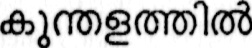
കുന്തളത്തില്‍
